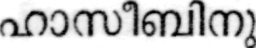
ഹാസീബിനു
